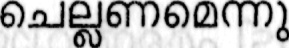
ചെല്ലണമെന്നു
